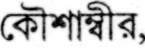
কৌশাম্বীর,
